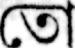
তো
